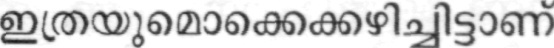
ഇത്രയുമൊക്കെക്കഴിച്ചിട്ടാണ്
